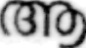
ആ
